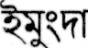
ইমুংদা
